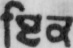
ਇਕ
